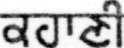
ਕਹਾਣੀ
